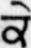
ਕੇ
